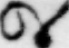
જ
